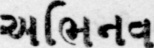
અભિનવ
